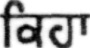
ਕਿਹਾ
